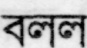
বলল
